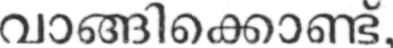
വാങ്ങിക്കൊണ്ട്,
